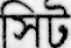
সিট
